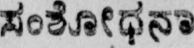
ಸಂಶೋಧನಾ
